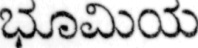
ಭೂಮಿಯ
